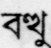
বত্থু
